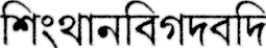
শিংথানবিগদবদি
